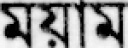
ময়াম
